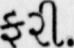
ફરી.
